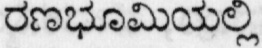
ರಣಭೂಮಿಯಲ್ಲಿ
